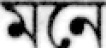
মনে
